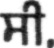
ਸੀ,
